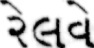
રેલવે
